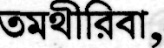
তমথীরিবা,
